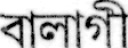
বালাগী
